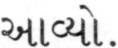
આવ્યો.
